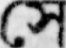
সে
